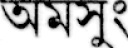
অমসুং
